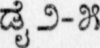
ಡೈ೨-೫
